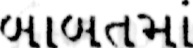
બાબતમાં
